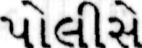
પોલીસે
